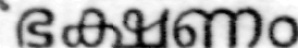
‘ഭക്ഷണം
